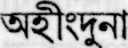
অহীংদুনা
